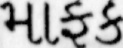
માફક
